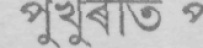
পুখুৰত
